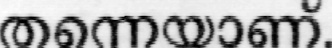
തന്നെയാണ്.
